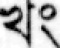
খং
